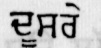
ਦੂਸਰੇ
